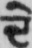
ਦੇ
